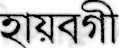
হায়বগী
